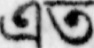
এত
